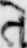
તે
